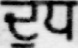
ਦੁਧ
